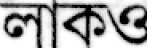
লাকও
